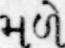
મળે
